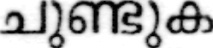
ചുണ്ടുക
